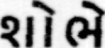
શોભે
